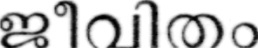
ജീവിതം
